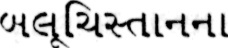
બલૂચિસ્તાનના
